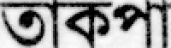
তাকপা
